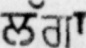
ਲੱਗਾ
